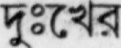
দুঃখের
